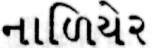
નાળિયેર
